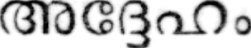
അദ്ദേഹം
